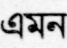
এমন
